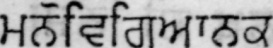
ਮਨੋਵਿਗਿਆਨਕ
